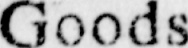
Goods
